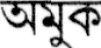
অমুক
